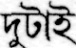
দুটাই
